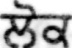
ਲੋਕ
